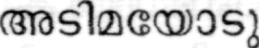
അടിമയോടു
